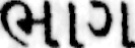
ભાગ
